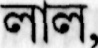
লাল,
